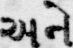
અને
